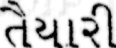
તૈયારી
